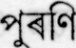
পুৰণি
